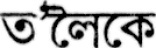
ত'লৈকে
